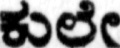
ಕುಲೇ
